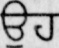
ਉਹ
